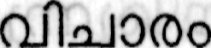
വിചാരം
